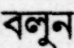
বলুন
